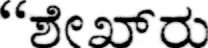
"ಶೇಖ್ರು
